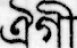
ঐগী
